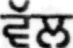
ਵੱਲ
